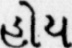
હોય
